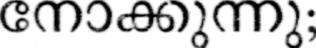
നോക്കുന്നു;
